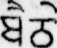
ਬੈਠੇ
